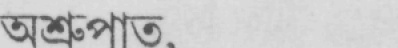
অশ্ৰুপাত,
